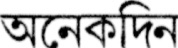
অনেকদিন
